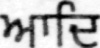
ਆਦਿ
